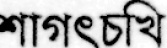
শাগৎচখি
